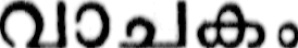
വാചകം
